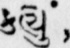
કહ્યું,
